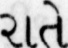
રાતે
